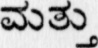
ಮತ್ತು
